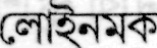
লোইনমক
